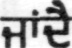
ਜਾਂਦੈ
